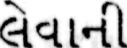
લેવાની
